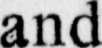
and
